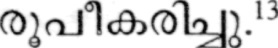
രൂപീകരിച്ചു.13
